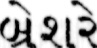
બ્રેશરે
